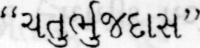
"ચતુર્ભુજદાસ"
